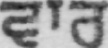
ਵਾਰ
